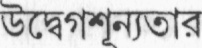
উদ্বেগশূন্যতার
